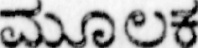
ಮೂಲಕ
